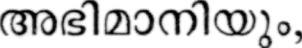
അഭിമാനിയും,
